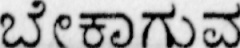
ಬೇಕಾಗುವ
